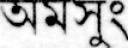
অমসুং
